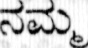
ನಮ್ಮ
